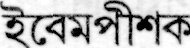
ইবেমপীশক
